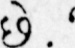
છે.
